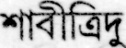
শাবীত্রিদু
